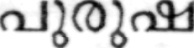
പുരുഷ
